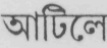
আটিলে
